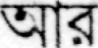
আর
